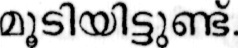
മൂടിയിട്ടുണ്ട്.
